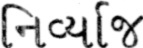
નિર્વ્યાજ
